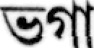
ভগা
